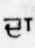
ਦਾ
